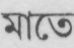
মাতে
